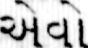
એવો
